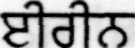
ਈਰੀਨ
